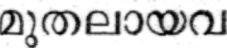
മുതലായവ
